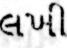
લખી
